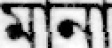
মানা
